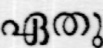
ഏതു
